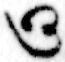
ও
